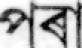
পৰা
